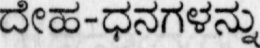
ದೇಹ-ಧನಗಳನ್ನು
